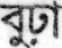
বুঢ়া
